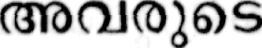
അവരുടെ
